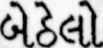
બેઠેલો
